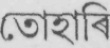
তোহাৰি
